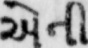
એની
